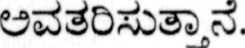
ಅವತರಿಸುತ್ತಾನೆ.
